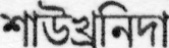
শাউখ্রনিদা
